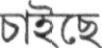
চাইছে
